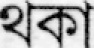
থকা
